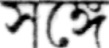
সঙ্গে
